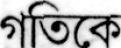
গতিকে
